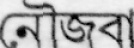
নৌজবা
